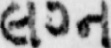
લગ્ન
